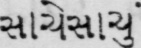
સાચેસાચું
